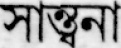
সান্ত্বনা
